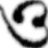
ও
